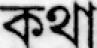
কথা
